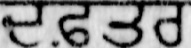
ਦਫ਼ਤਰ
